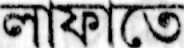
লাফাতে
